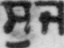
ਸੁਜ
